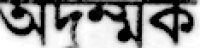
অদুম্মক
